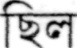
ছিল
